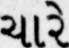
ચારે
